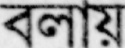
বলায়
